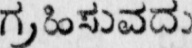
ಗ್ರಹಿಸುವುದು
